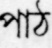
পাঠ
